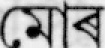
মোৰ
